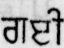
ਗਈ
